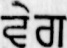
ਵੇਗ
